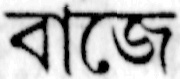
বাজে
